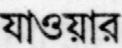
যাওয়ার
